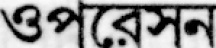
ওপরেসন
